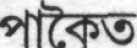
পাকৈত
